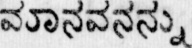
ಮಾನವನನ್ನು
